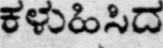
ಕಳುಹಿಸಿದ
